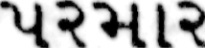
પરમાર
